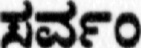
ಸರ್ವಂ
